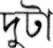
দুটা
